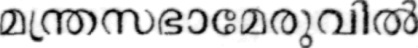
മന്ത്രസഭാമേരുവില്‍
